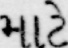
માટે
